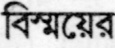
বিস্ময়ের
